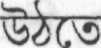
উঠতে
